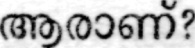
ആരാണ്?
